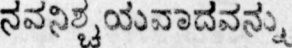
ನವನಿಶ್ಚಯವಾದವನ್ನು
